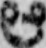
ಆ
